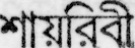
শায়রিবী
